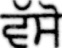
ਵੱਸੋ
